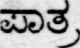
ಪಾತ್ರ
